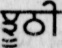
ਝੂਠੀ
